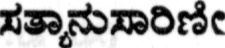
ಸತ್ಯಾನುಸಾರಿಣೀ
